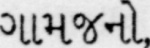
ગામજનો,
